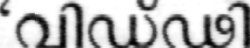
‘വിഡ്ഢി
